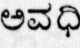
ಅವಧಿ
